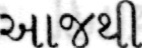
આજથી
